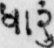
ધારું
